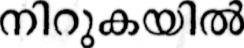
നിറുകയില്‍
